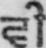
ਵੀ
